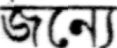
জন্যে
